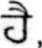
ਹੈ,
